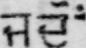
ਜਦੋਂ
